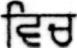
ਵਿਚ
